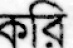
করি
